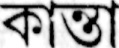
কান্তা
